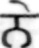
ਨੇ
